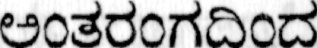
ಅಂತರಂಗದಿಂದ
